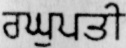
ਰਘੁਪਤੀ
